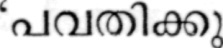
'പവതിക്കു
